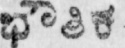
ಭೌತಿಕ
